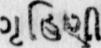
ગૃહિણી
